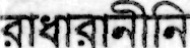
রাধারানীনি
